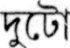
দুটো
